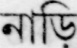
নাড়ি
